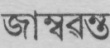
জাম্বৱন্ত
